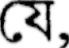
যে,
